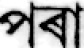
পৰা
